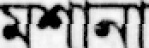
মশানা
